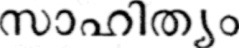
സാഹിത്യം
